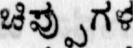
ಚಿಪ್ಪುಗಳ
